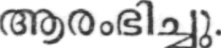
ആരംഭിച്ചു.
